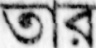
তার
